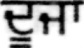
ਦੂਜਾ
